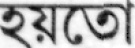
হয়তো
